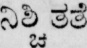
ನಿಶ್ಚಿತತೆ
